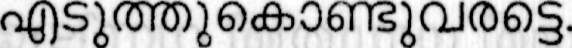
എടുത്തുകൊണ്ടുവരട്ടെ.
